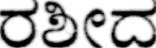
ರಶೀದ
